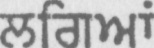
ਲਗਿਆਂ
